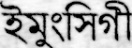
ইমুংসিগী
